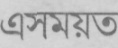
এসময়ত
